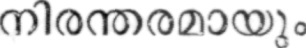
നിരന്തരമായും
